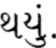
થયું.
